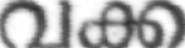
വക്ക
